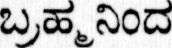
ಬ್ರಹ್ಮನಿಂದ
